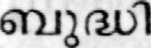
ബുദ്ധി
